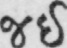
જઈ
